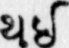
થઈ
